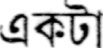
একটা
